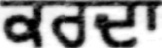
ਕਰਦਾ
